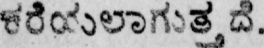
ಕರೆಯಲಾಗುತ್ತದೆ.
